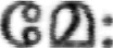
മേ:
